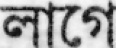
লাগে
